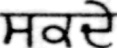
ਸਕਦੇ
